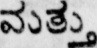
ಮತ್ತು
